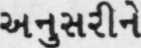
અનુસરીને
